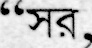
“সর,
